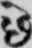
છે
